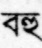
বহু
